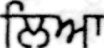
ਲਿਆ
